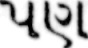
પણ
